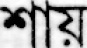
শায়
